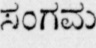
ಸಂಗಮ
